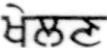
ਖੇਲਣ
